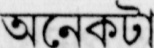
অনেকটা
